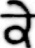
ਕੇ
